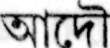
আদৌ
